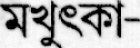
মখুৎকা-
